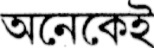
অনেকেই
